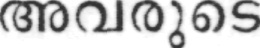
അവരുടെ
